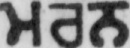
ਮਰਨ
